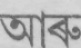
আৰু
